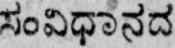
ಸಂವಿಧಾನದ
